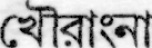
খৌরাংনা
